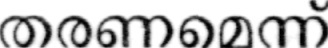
തരണമെന്ന്
